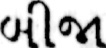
બીજા
